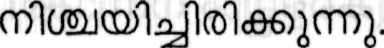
നിശ്ചയിച്ചിരിക്കുന്നു.
